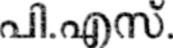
പി.എസ്.
